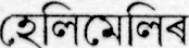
হেলিমেলিৰ
